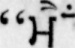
''ਮੈਂ
